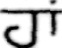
ਹਾਂ
